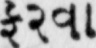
ફરવા
